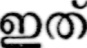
ഇത്
